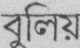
বুলিয়
